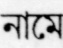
নামে
